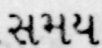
સમય
